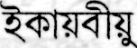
ইকায়বীয়ু
